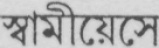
স্বামীয়েসে
